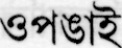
ওপঙাই
